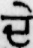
ਦੇ
